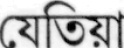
যেতিয়া
